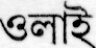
ওলাই
